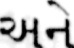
અને
